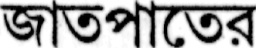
জাতপাতের
